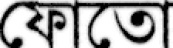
ফোতি
